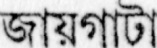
জায়গাটা
